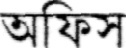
অফিস
